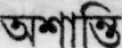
অশান্তি
